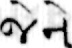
જેને
